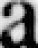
a
